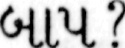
બાપ?
